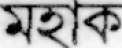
মহাক
